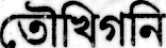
তৌখিগনি
